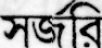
সর্জরি
